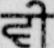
ਵੀ
